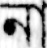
না
